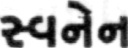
સ્વનેન
